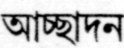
আচ্ছাদন
